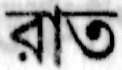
রাত
